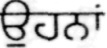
ਉਹਨਾਂ
